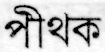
পীথক
